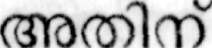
അതിന്
